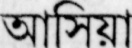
আসিয়া
